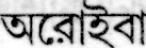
অরোইবা
